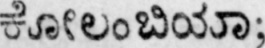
ಕೋಲಂಬಿಯಾ;
